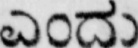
ಎಂದು
